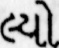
લ્યો
